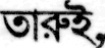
তারুই,
